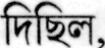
দিছিল,
